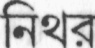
নিথর
